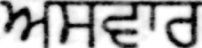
ਅਸਵਾਰ
